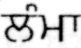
ਲੰਮਾ
